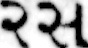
રસ
